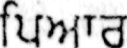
ਪਿਆਰ
